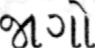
જાગો
